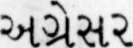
અગ્રેસર
